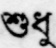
শুধু
